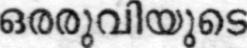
ഒരരുവിയുടെ
